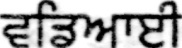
ਵਡਿਆਈ
